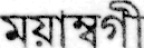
ময়াম্বগী
